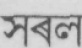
সৰল
